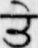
ਤੇ
